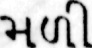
મળી
